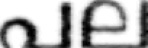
പല
